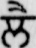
ਲੈ
